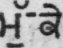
ਮੁੱਕੇ
